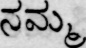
ನಮ್ಮ
